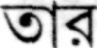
তার
